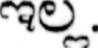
ಇಲ್ಲ.
